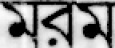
মরম
